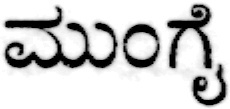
ಮುಂಗೈ
